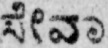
ಸೇವಾ
